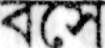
বসে
